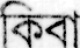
কিবা
